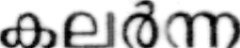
കലര്‍ന്ന
